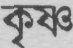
কৃষ্ণ
